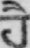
ਹੈ
